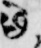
છે,
